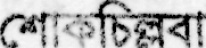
শোকচিল্লবা
